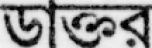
ডাক্তর
